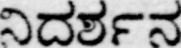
ನಿದರ್ಶನ
